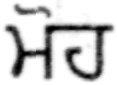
ਮੋਹ
